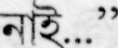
নাই..."
